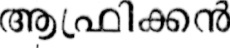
ആഫ്രിക്കന്‍
